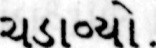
ચડાવ્યો.
